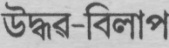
উদ্ধৱ-বিলাপ
